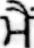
ਮੈਂ
